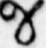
જ
